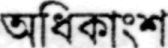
অধিকাংশ
